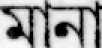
মানা
